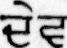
ਦੇਵ
